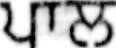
ਪਾਲ
